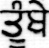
ਤੂੰਬੇ
